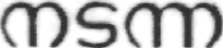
നടന്ന
